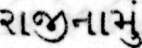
રાજીનામું
